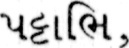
પટ્ટાભિ,
